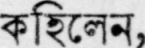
কহিলেন,
